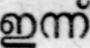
ഇന്ന്
